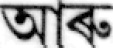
আৰু
